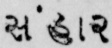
સંહાર
